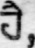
ਹੈ,
